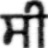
ਸੀ
